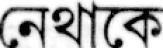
নেথাকে
